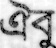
ঐবু
